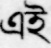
এই
